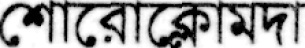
শোরোক্লোমদা
